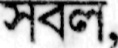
সবল,
